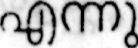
എന്നു
